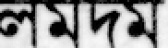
লমদম
